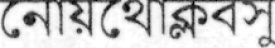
নোয়থোক্লবসু
